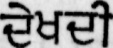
ਦੇਖਦੀ
